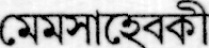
মেমসাহেবকী
